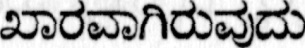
ಖಾರವಾಗಿರುವುದು
